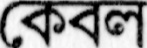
কেবল
